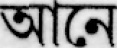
আনে
